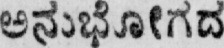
ಅನುಭೋಗದ
